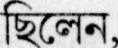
ছিলেন,
